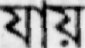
যায়
